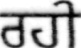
ਰਹੀ
